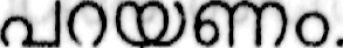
പറയണം.
